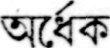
অর্ধেক
